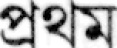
প্রথম
